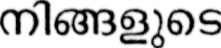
നിങ്ങളുടെ
